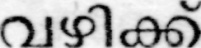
വഴിക്ക്
